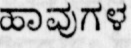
ಹಾವುಗಳ
